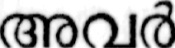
അവര്‍
